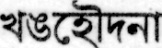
খঙহৌদনা
